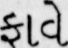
ફાવે
